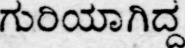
ಗುರಿಯಾಗಿದ್ದ
